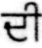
ਦੀ
